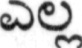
ಎಲ್ಲ
